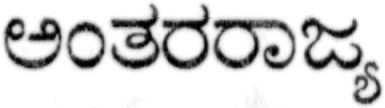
ಅಂತರರಾಜ್ಯ
